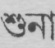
শুনা
